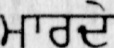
ਮਾਰਦੇ
